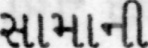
સામાની
